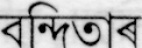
বন্দিতাৰ
